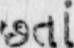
છતાં
